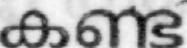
കണ്ട
